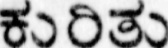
ಕುರಿತು
